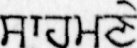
ਸਾਹਮਣੇ
